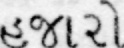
હજારો
